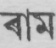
ৰাম
